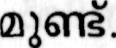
മുണ്ട്.
